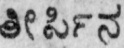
ತೀರ್ಪಿನ
